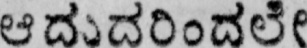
ಆದುದರಿಂದಲೇ
